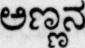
ಅಣ್ಣನ
